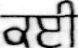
ਕਈ
